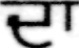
ਦਾ
